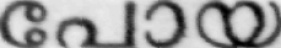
പോയ
